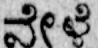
ವೇಳೆ
